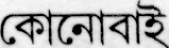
কোনোবাই
